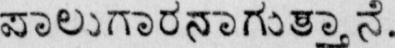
ಪಾಲುಗಾರನಾಗುತ್ತಾನೆ.
